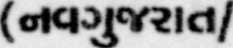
(નવગુજરાત/
